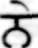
ਨੇ
